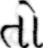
તો
